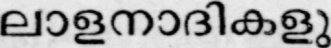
ലാളനാദികളു
